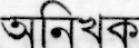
অনিখক
